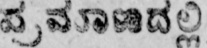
ಪ್ರಮಾಣದಲ್ಲಿ
